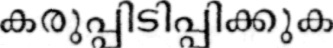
കരുപ്പിടിപ്പിക്കുക
